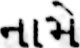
નામે
